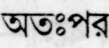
অতঃপর
